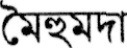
মৈহুমদা
